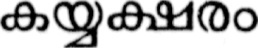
കയ്യക്ഷരം
